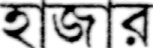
হাজার
